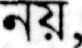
নয়,
